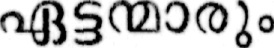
ഏട്ടന്മാരും
